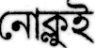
নোক্লুই
